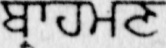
ਬ੍ਰਾਹਮਣ
